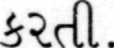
કરતી.
